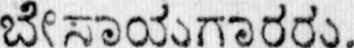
ಬೇಸಾಯಗಾರರು.
